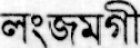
লংজমগী
